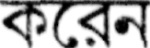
করেন
